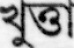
খুত্তা
